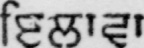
ਇਲਾਵਾ
